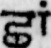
ਛਾਂ
